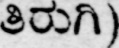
ತಿರುಗಿ)
